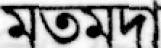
মতমদা
